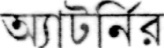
অ্যাটর্নির
